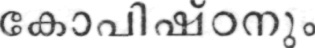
കോപിഷ്ഠനും
